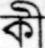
কী
